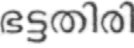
ഭട്ടതിരി
